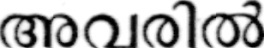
അവരില്‍
